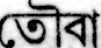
তৌবা
